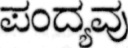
ಪಂದ್ಯವು
